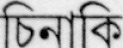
চিনাকি
